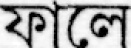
ফালে
